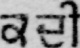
ਕਦੀ
